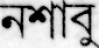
নশাবু
